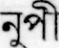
নুপী
